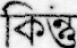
কিন্তু
